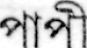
পাপী
